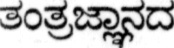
ತಂತ್ರಜ್ಞಾನದ
